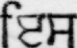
ਇਸ
